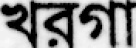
খরগা
